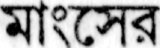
মাংসের
